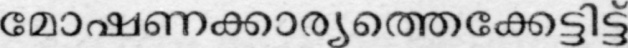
മോഷണക്കാര്യത്തെക്കേട്ടിട്ട്
